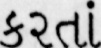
કરતાં
